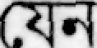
যেন
